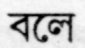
বলে
